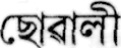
ছোৱালী
